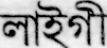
লাইগী
